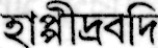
হাপ্পীদ্রবদি
